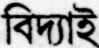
বিদ্যাই
